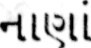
નાણાં
